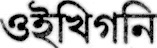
ওইখিগনি
